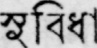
সুবিধা
